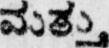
ಮತ್ತು
